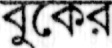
বুকের
